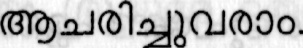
ആചരിച്ചുവരാം.
